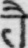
ਹੈ
